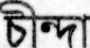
চীন্দা
